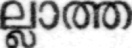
ല്ലാത്ത
